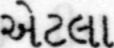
એટલા
